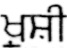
ਖ਼ੁਸ਼ੀ
